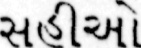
સહીઓ
